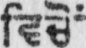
ਵਿਚੋਂ
